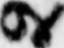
જ
